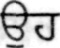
ਉਹ
